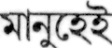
মানুহেই
